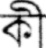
কী
